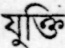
যুক্তি
